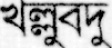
খল্লুবদু
